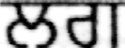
ਲਗ
